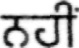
ਨਹੀਂ
